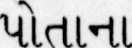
પોતાના
